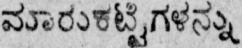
ಮಾರುಕಟ್ಟೆಗಳನ್ನು
